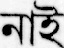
নাই
